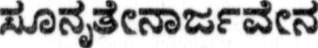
ಸೂನೃತೇನಾರ್ಜವೇನ
